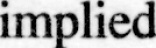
implied
